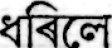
ধৰিলে
